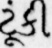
ટૂંકી
